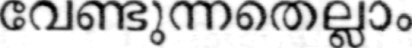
വേണ്ടുന്നതെല്ലാം
